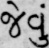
જેવું
